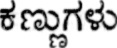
ಕಣ್ಣುಗಳು
